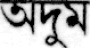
অদুম
